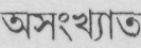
অসংখ্যাত
